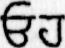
ਓਹ
